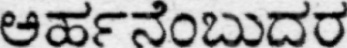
ಅರ್ಹನೆಂಬುದರ
